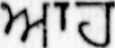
ਆਹ
